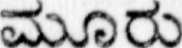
ಮೂರು
